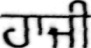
ਹਾਜੀ
